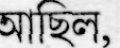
আছিল,
